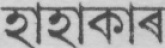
হাহাকাৰ
